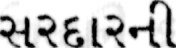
સરદારની
